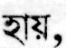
হায়,
